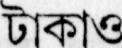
টাকাও
